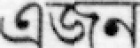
এজন
